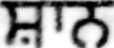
ਸ਼ਾਨ
